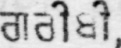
ਗਰੀਬੀ,
